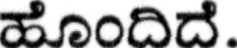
ಹೊಂದಿದೆ.
